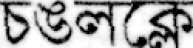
চঙলক্লে
